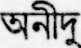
অনীদু
